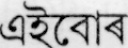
এইবোৰ
